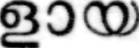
ളായ
